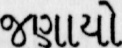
જણાયો
